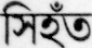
সিহঁত
